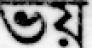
ভয়
